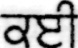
ਕਈ
